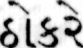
ઠોકરે
